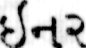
ઇનર
